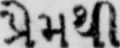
પ્રેમથી
